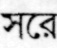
সরে
